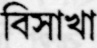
বিসাখা
